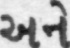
અને
